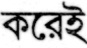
করেই
